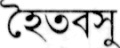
হৈতবসু
